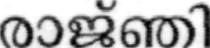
രാജ്ഞി
